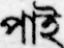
পাই
